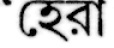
“হেরা
